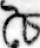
চৈ
